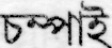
চম্পাই
